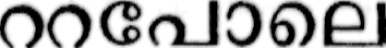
ററപോലെ
